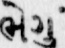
ભેગું
